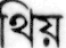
থিয়
